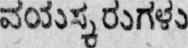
ವಯಸ್ಕರುಗಳು
